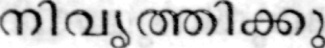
നിവൃത്തിക്കു
